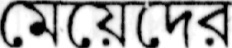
মেয়েদের
